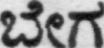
ಬೇಗ
